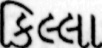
કિલ્લા
